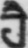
ਹੈ
